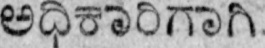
ಅಧಿಕಾರಿಗಾಗಿ
